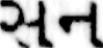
સન
